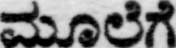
ಮೂಲೆಗೆ
